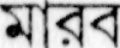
মারব
